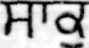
ਸਾਕੁ
